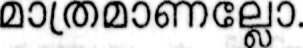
മാത്രമാണല്ലോ.
